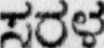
ಸರಳ
